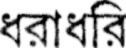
ধরাধরি
